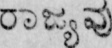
ರಾಜ್ಯವು
